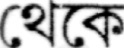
থেকে
